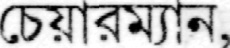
চেয়ারম্যান,
